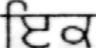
ਇਕ
